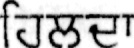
ਹਿਲਦਾ
